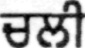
ਚਲੀ
